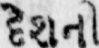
દેશની
